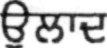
ਉਲਾਦ
